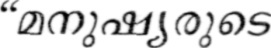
“മനുഷ്യരുടെ
